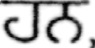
ਹਨ,
